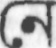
নে
